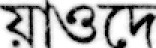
য়াওদে
